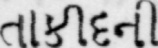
તાકીદની
